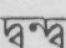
দ্বন্দ্ব
